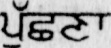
ਪੁੱਛਣਾ
